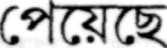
পেয়েছে
